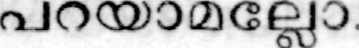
പറയാമല്ലോ.
